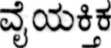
ವೈಯಕ್ತಿಕ
